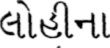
લોહીના
